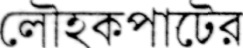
লৌহকপাটের
